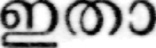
ഇതാ
